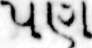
પણ
